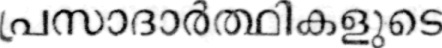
പ്രസാദാര്‍ത്ഥികളുടെ
